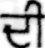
ਦੀ
